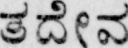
ತದೇವ
